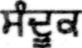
ਸੰਦੂਕ
